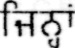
ਜਿਨ੍ਹਾਂ
